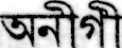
অনীগী
